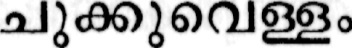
ചുക്കുവെള്ളം
